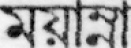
ময়াম্না
